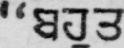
''ਬਹੁਤ
